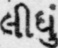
લીધું
